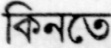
কিনতে
